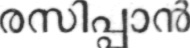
രസിപ്പാന്‍
